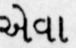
એવા
